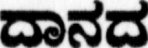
ದಾನದ
